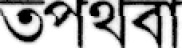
তপথবা
